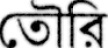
তৌরি
